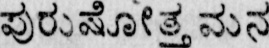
ಪುರುಷೋತ್ತಮನ
